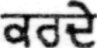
ਕਰਦੇ
